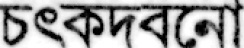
চৎকদবনো
